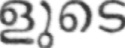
ളുടെ
